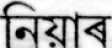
নিয়াৰ
